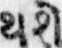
થશે
